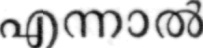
എന്നാല്‍
